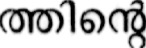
ത്തിന്റെ
